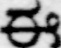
ಈ
